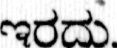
ಇರದು.
